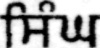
ਸਿੰਘ
